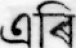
এৰি
